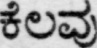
ಕೆಲವು
